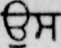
ਉਸ
